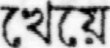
খেয়ে
